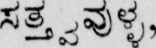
ಸತ್ತ್ವವುಳ್ಳ,
